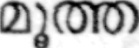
മൂത്ത
